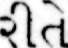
રીતે
